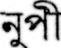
নুপী
